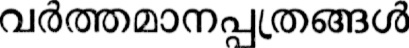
വര്‍ത്തമാനപ്പത്രങ്ങള്‍
